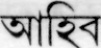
আহিব
